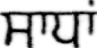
ਸਾਧਾਂ
